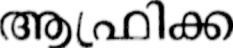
ആഫ്രിക്ക
